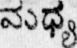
ಮಧ್ಯ
